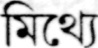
মিথ্যে
